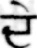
ਦੇ
